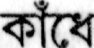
কাঁধে
